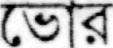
ভোর
